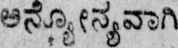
ಅನ್ಯೋನ್ಯವಾಗಿ
